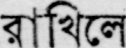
রাখিলে
